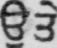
ਉਤੇ
